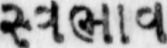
સ્વભાવ
